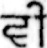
ਵੀ
